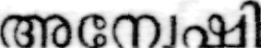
അന്വേഷി
